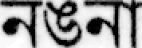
নঙনা
